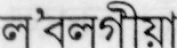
ল'বলগীয়া
